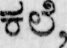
ಕಲೆ,
